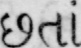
છતાં
